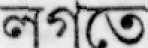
লগতে
